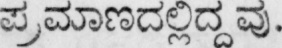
ಪ್ರಮಾಣದಲ್ಲಿದ್ದವು.
